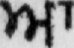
ਆ
